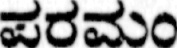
ಪರಮಂ
